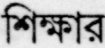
শিক্ষার
